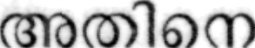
അതിനെ
